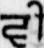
ਵੀ
